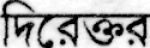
দিরেক্তর
